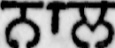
ਨਾਲ
